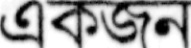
একজন
